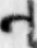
ન
